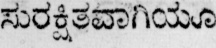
ಸುರಕ್ಷಿತವಾಗಿಯೂ
